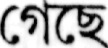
গেছে
